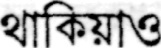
থাকিয়াও
